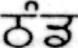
ਠੰਡ
